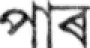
পাৰ
